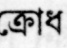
ক্রোধ
